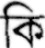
কি
